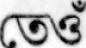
তেওঁ
